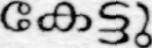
കേട്ടു
